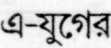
এ-যুগের
